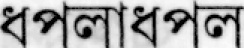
ধপলাধপল
